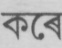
কৰে
